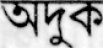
অদুক
